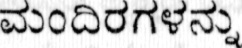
ಮಂದಿರಗಳನ್ನು
